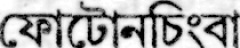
ফোটোনচিংবা
